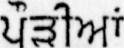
ਪੌੜੀਆਂ
